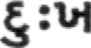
દુઃખ
